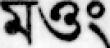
মওং
